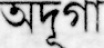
অদূগা
